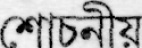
শোচনীয়
